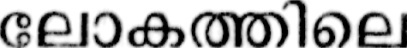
ലോകത്തിലെ
